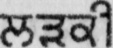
ਲੜਕੀ
